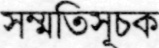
সম্মতিসূচক
